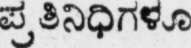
ಪ್ರತಿನಿಧಿಗಳೂ
